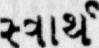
સ્વાર્થ
